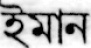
ইমান
